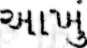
આખું
